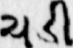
ચડી
